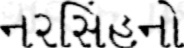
નરસિંહનો
